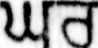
ਘਰ
